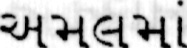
અમલમાં
